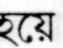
হয়ে
